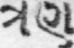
ત્રણ
